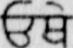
ਓਥੇ
